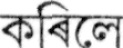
কৰিলে
